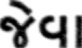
જેવા
